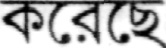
করেছে
